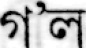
গ'ল
